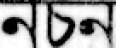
নচন
